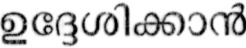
ഉദ്ദേശിക്കാന്‍
